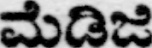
ಮೆಡಿಜಿ
